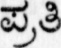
ಪ್ರತಿ
